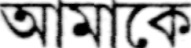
আমাকে
